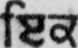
ਇਕ
